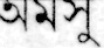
অমসু
